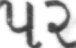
પર
